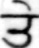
ਤੇ
